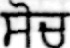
ਸੋਚ
